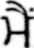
ਮੈਂ
